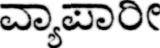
ವ್ಯಾಪಾರೀ
